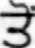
ਤੋਂ
